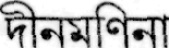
দীনমণিনা
